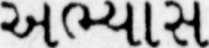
અભ્યાસ
